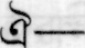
ঐ-
